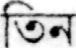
তিন
